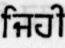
ਜਿਹੀ
